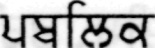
ਪਬਲਿਕ
